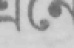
এনে
